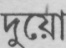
দুয়ো
